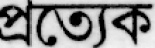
প্রত্যেক
